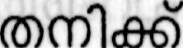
തനിക്ക്
